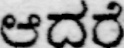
ಆದರೆ
